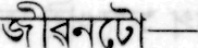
জীৱনটো-
